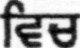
ਵਿਚ
